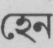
হেন
